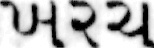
ખરચ
